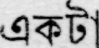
একটা
